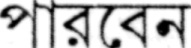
পারবেন
